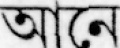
আনে
